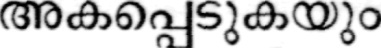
അകപ്പെടുകയും
